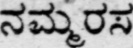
ನಮ್ಮರಸ
